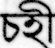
চহী
